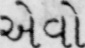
એવો
